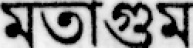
মতাগুম
